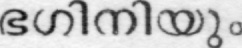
ഭഗിനിയും
